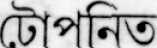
টোপনিত
